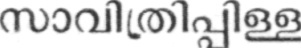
സാവിത്രിപ്പിള്ള
